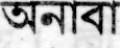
অনাবা
